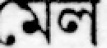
মেল
